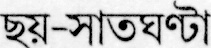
ছয়-সাতঘণ্টা
